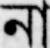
না
